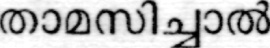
താമസിച്ചാല്‍
